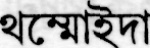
থম্মোইদা
